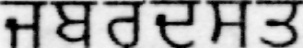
ਜਬਰਦਸਤ
